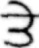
ਤੇ
